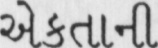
એકતાની
